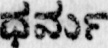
ಧರ್ಮ
